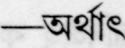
–অর্থাৎ
